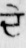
ਦੇ
